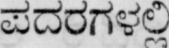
ಪದರಗಳಲ್ಲಿ
